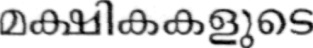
മക്ഷികകളുടെ
